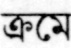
ক্রমে
